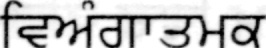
ਵਿਅੰਗਾਤਮਕ
